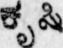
ಕೃಷಿ
